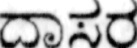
ದಾಸರ
